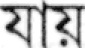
যায়
